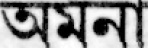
অমনা
